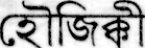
হৌজিক্কী
